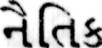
નૈતિક
